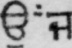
ਉਂਜ
